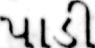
પાડી
